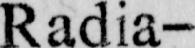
Radia-
